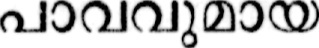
പാവവുമായ
